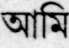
আমি
